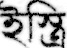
ইস্ত্রি
